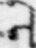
ને
